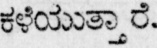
ಕಳೆಯುತ್ತಾರೆ.
